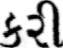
કરી
